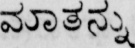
ಮಾತನ್ನು
